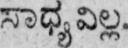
ಸಾಧ್ಯವಿಲ್ಲ.
